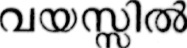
വയസ്സില്‍
